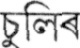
চুলিৰ
